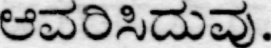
ಆವರಿಸಿದುವು.
